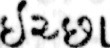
ઈચ્છા
